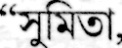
“সুমিতা,
